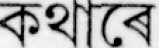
কথাৰে
